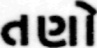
તણો
